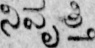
ನಿವೃತ್ತಿ
